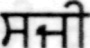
ਸਜੀ
